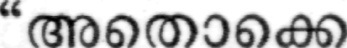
“അതൊക്കെ
